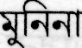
মুনিনা
